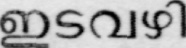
ഇടവഴി
